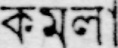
কমলা
